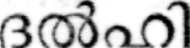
ദല്‍ഹി
